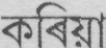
কৰিয়া
